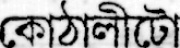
কোঠালীটো
